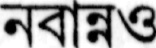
নবান্নও
